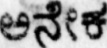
ಅನೇಕ
